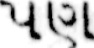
પણ
